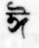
ঈ
